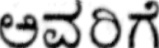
ಅವರಿಗೆ
